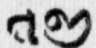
તજી
